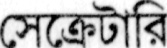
সেক্রেটারি
